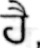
ਹੈ,
